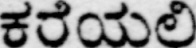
ಕರೆಯಲಿ
